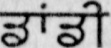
ਡਾਂਡੀ
